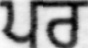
ਪਰ
